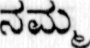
ನಮ್ಮ
